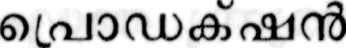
പ്രൊഡക്ഷന്‍
